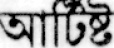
আর্টিষ্ট
